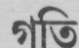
গতি
